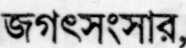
জগত্সংসার,
